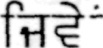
ਜਿਵੇਂ
